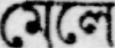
মেলে
